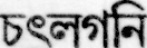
চৎলগনি
